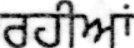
ਰਹੀਆਂ
